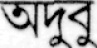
অদুবু
